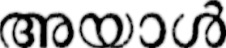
അയാള്‍
